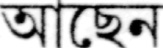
আছেন
